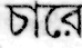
চারে
